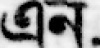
এন.
